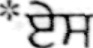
*ਏਸ
